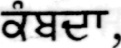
ਕੰਬਦਾ,
